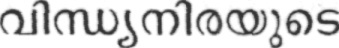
വിന്ധ്യനിരയുടെ
